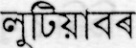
লুটিয়াবৰ
